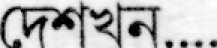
দেশখন....
